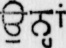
ਉਨ੍ਹਾਂ
